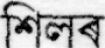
শিলৰ
